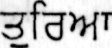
ਤੁਰਿਆ
